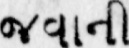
જવાની
